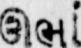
ઊભાં
